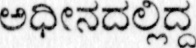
ಅಧೀನದಲ್ಲಿದ್ದ
